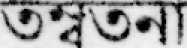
তম্বতনা
